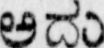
ಅದು
